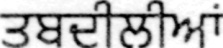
ਤਬਦੀਲੀਆਂ
